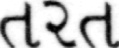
તરત
